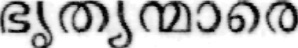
ഭൃത്യന്മാരെ
